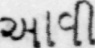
આવી
